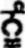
ਨੂੰ
